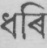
ধৰি
